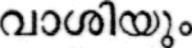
വാശിയും
